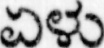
ಏಳು
